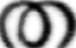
ത
